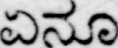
ಏನೂ
